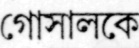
গোসালকে
